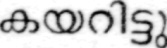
കയറിട്ടു
